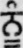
ਨੂੰ
